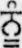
ਨੂੰ
